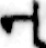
ન
